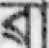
ৱা
